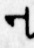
ન
